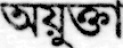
অয়ুক্তা
